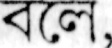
বলে,
